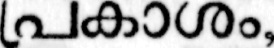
പ്രകാശം,
